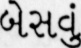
બેસવું
